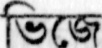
ভিজে
